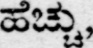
ಹೆಚ್ಚು,
